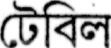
টেবিল
